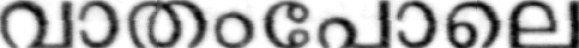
വാതംപോലെ
